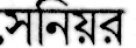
সেনিয়র
